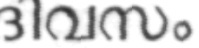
ദിവസം
